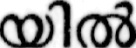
യില്‍
